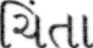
ચિંતા
